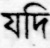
যদি
